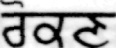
ਰੋਕਣ
